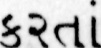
કરતાં
